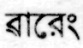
ৱারেং
